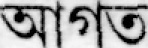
আগত
